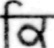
ਕਿ
